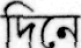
দিনে
